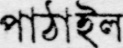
পাঠাইল
